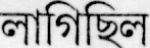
লাগিছিল
